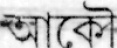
আকৌ
